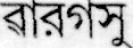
ৱারগসু
